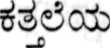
ಕತ್ತಲೆಯ
